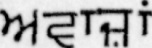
ਅਵਾਜ਼ਾਂ
